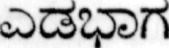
ಎಡಭಾಗ
